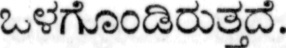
ಒಳಗೊಂಡಿರುತ್ತದೆ.
